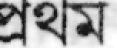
প্রথম
